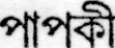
পাপকী
